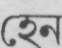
হেন
